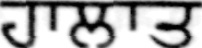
ਹਾਲਾਤ
